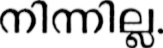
നിന്നില്ല.
